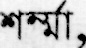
শর্ম্মা,
